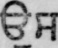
ਉਸ
